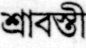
শ্রাবস্তী
